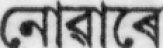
নোৱাৰে
